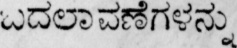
ಬದಲಾವಣೆಗಳನ್ನು
